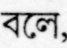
বলে,
